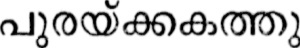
പുരയ്ക്കകത്തു
